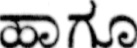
ಹಾಗೂ
